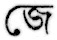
জে
